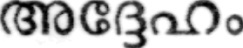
അദ്ദേഹം
